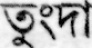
তুংদা
